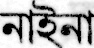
নাইনা
